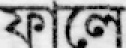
ফালে
